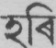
হৰি
